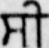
ਸੀ
